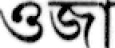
ওজা
